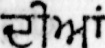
ਦੀਆਂ
